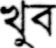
খুব
